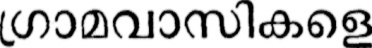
ഗ്രാമവാസികളെ
